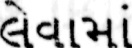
લેવામાં
